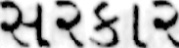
સરકાર
